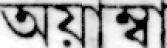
অয়াম্বা
